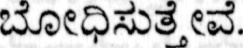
ಬೋಧಿಸುತ್ತೇವೆ.
